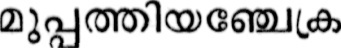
മുപ്പത്തിയഞ്ചേക്ര
